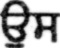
ਉਸ
